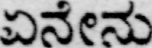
ಏನೇನು
